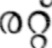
രറ്റ്
